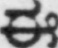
ಈ
